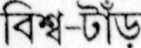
বিশ্ব-টাঁড়
